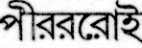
পীরররোই
